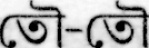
তৌ-তৌ
